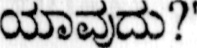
ಯಾವುದು?
